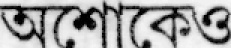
অশোকেও
